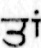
ਤਾਂ
